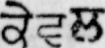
ਕੇਵਲ
